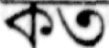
কত
